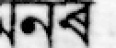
মনৰ
